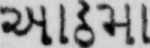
આઠમા
